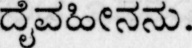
ದೈವಹೀನನು.
